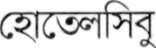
হোতেলসিবু
